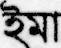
ইমা
